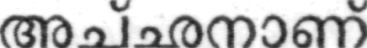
അച്ഛനാണ്
